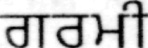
ਗਰਮੀ
